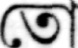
তো
